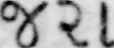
જરા
